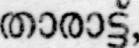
താരാട്ട്,
